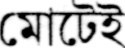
মোটেই
